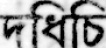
দধিচি
